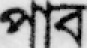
পাব
